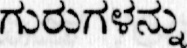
ಗುರುಗಳನ್ನು
